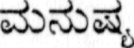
ಮನುಷ್ಯ
